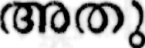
അതു
